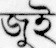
জুই
